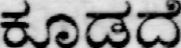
ಕೂಡದೆ
